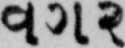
વગર
